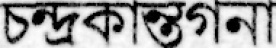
চন্দ্রকান্তগনা
